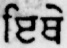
ਇਥੇ
